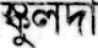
স্কুলদা
